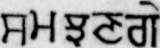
ਸਮਝਣਗੇ
